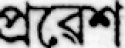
প্রৱেশ
